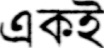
একই
